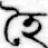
হৈ
